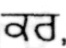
ਕਰ,
